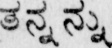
ತನ್ನನ್ನು
